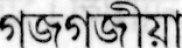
গজগজীয়া
